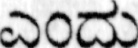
ಎಂದು
